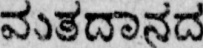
ಮತದಾನದ
